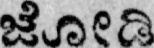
ಜೋಡಿ
